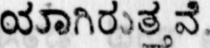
ಯಾಗಿರುತ್ತವೆ.
